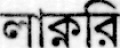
লাক্নরি
